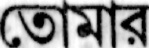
তোমার
